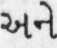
અને
